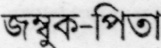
জম্বুক-পিতা
